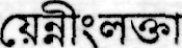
য়েন্নীংলক্তা
